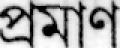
প্রমাণ
